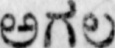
ಅಗಲ
